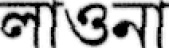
লাওনা
